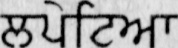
ਲਪੇਟਿਆ
